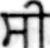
ਸੀ
